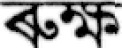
ৰুক্ষ
